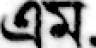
এম.
